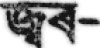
জ্বৰ-
